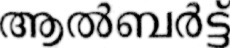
ആല്‍ബര്‍ട്ട്
